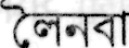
লৈনবা
